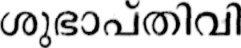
ശുഭാപ്തിവി
